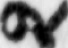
જ
